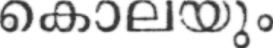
കൊലയും
